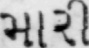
મારી
